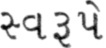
સ્વરૂપે
